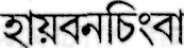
হায়বনচিংবা
